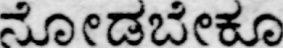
ನೋಡಬೇಕೂ
